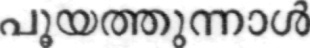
പൂയത്തുന്നാള്‍
